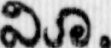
ಮೀ.
